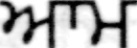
ਆਮ
